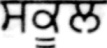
ਸਕੂਲ
